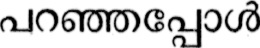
പറഞ്ഞപ്പോള്‍
